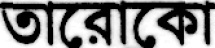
তারোকো
